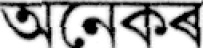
অনেকৰ
